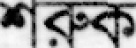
শরুক
